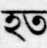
হত
